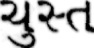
ચુસ્ત
